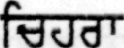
ਚਿਹਰਾ
